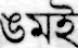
ঙমই
